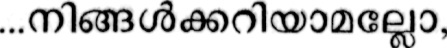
...നിങ്ങള്‍ക്കറിയാമല്ലോ,
